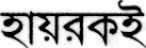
হায়রকই
